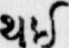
થઈ
